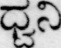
ಧ್ವನಿ
